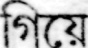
গিয়ে
